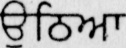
ਉਠਿਆ
